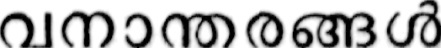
വനാന്തരങ്ങള്‍
